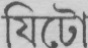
যিটো
